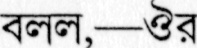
বলল,–ঔর
